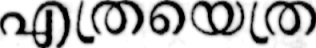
എത്രയെത്ര
